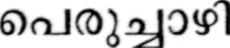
പെരുച്ചാഴി
